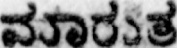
ಮಾರುತ
